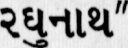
રઘુનાથ"
